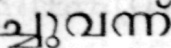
ച്ചുവന്ന്
